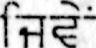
ਜਿਵੇਂ
